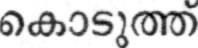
കൊടുത്ത്
